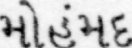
મોહંમદ
